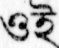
ওই
